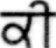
ਕੀ
